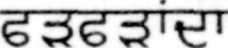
ਫੜਫੜਾਂਦਾ
